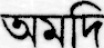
অমদি
